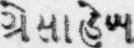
ગ્રેસાહેબ
